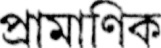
প্রামাণিক
